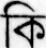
কি
